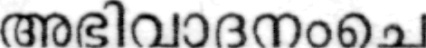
അഭിവാദനംചെ
